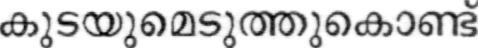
കുടയുമെടുത്തുകൊണ്ട്
